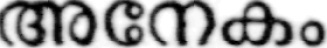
അനേകം
